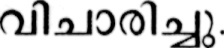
വിചാരിച്ചു.
